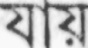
যায়
